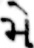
મે
